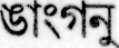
ঙাংগনু
